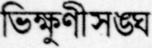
ভিক্ষুণীসঙ্ঘ
